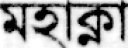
মহাক্না
